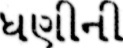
ધણીની
